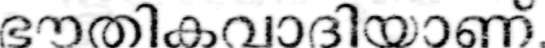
ഭൌതികവാദിയാണ്.
